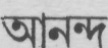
আনন্দ
